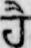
ਹੈ
